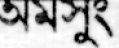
অমসুং
